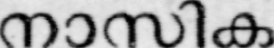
നാസിക
